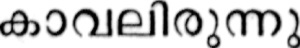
കാവലിരുന്നു
